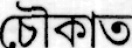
চৌকাত
